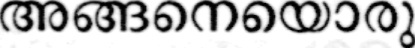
അങ്ങനെയൊരു
